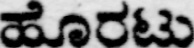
ಹೊರಟು
